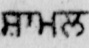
ਸ਼ਾਮਲ
